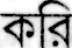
করি
